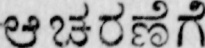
ಆಚರಣೆಗೆ
